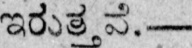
ಇರುತ್ತವೆ.-
